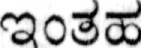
ಇಂತಹ
